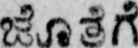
ಜೊತೆಗೆ
